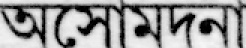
অসোমদনা
